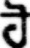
ਹੋ
